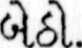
બેઠો.
